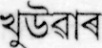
খুউৱাৰ
